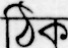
ঠিক
